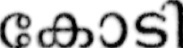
കോടി
